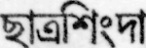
ছাত্রশিংদা
